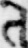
તે
